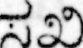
ಸಖಿ
